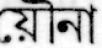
য়ৌনা
